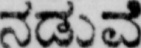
ನಡುವೆ
